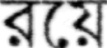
রয়ে
